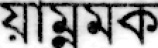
য়াম্নমক
